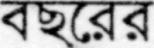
বছরের
